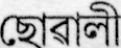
ছোৱালী
